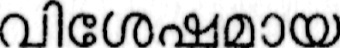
വിശേഷമായ
